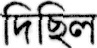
দিছিল
